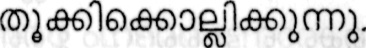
തൂക്കിക്കൊല്ലിക്കുന്നു.
